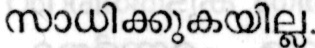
സാധിക്കുകയില്ല.
